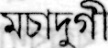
মচাদুগী
